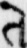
તે
